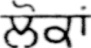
ਲੋਕਾਂ
